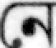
নে
